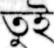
তুই
